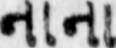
નાના
